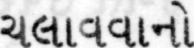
ચલાવવાનો
